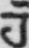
ਹੋ
